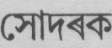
সোদৰক
